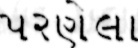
પરણેલા
